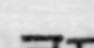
ਵਲ
